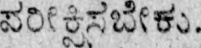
ಪರೀಕ್ಷಿಸಬೇಕು.
